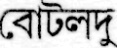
বোটলদু
